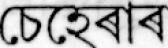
চেহেৰাৰ
